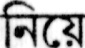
নিয়ে
